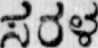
ಸರಳ
